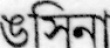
ঙসিনা
